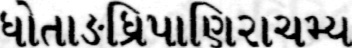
ધોતાઙધ્રિપાણિરાચ્મય
